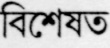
বিশেষত
